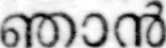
ഞാന്‍
